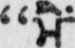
''ਮੈਂ
